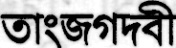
তাংজগদবী
